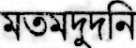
মতমদুদনি
